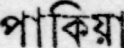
পাকিয়া
